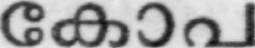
കോപ
